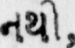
નથી,
